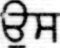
ਉਸ
